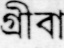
গ্রীবা
